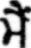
ਮੈਂ
